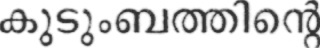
കുടുംബത്തിന്റെ
